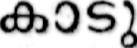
കാടു
